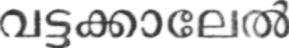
വട്ടക്കാലേല്‍
